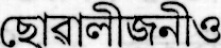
ছোৱালীজনীও
